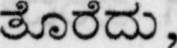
ತೊರೆದು,
